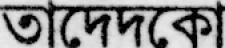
তাদেদকো
